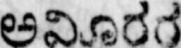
ಅಮೀರರ
